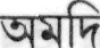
অমদি
